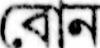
বোন
